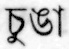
চুঙা
